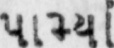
પામ્યાં
